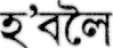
হ'বলৈ
